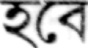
হবে
